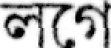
লগে
